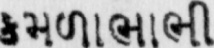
કમળાભાભી
